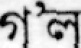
গ'ল
